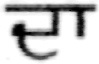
ਦਾ
